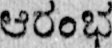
ಆರಂಭ
